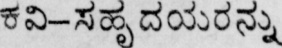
ಕವಿ-ಸಹೃದಯರನ್ನು
